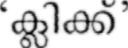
‘ക്ലിക്ക്'
